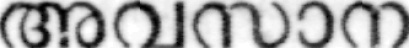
അവസാന
